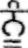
ਨੂੰ
